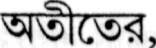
অতীতের,
